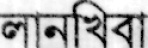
লানখিবা
